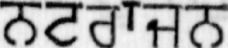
ਨਟਰਾਜਨ
